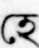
হে
